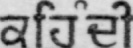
ਕਹਿੰਦੀ
